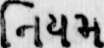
નિયમ
